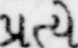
પ્રત્યે
